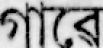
গাৱে
